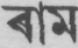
ৰাম
